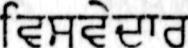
ਵਿਸਵੇਦਾਰ
